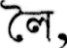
লৈ,
